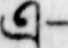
এ-
